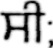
ਸੀ;
